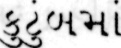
કુટુંબમાં
